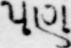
પણ
